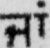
ਜਾਂ
